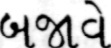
બજાવે
